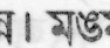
মঙ
